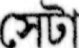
সেটা
